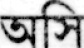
অসি
